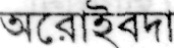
অরোইবদা
